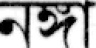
নঙ্গা
